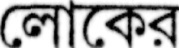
লোকের
